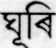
ঘূৰি
